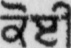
ਕੋਈ
